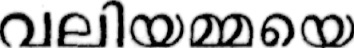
വലിയമ്മയെ
